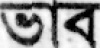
ভাব
